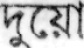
দুয়ো
